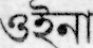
ওইনা
